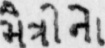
મૈત્રીનો
